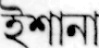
ইশানা
